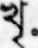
খৃ.
